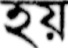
হয়
